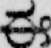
ಈ
